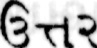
ઉત્તર
